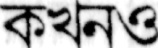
কখনও
